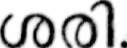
ശരി.
